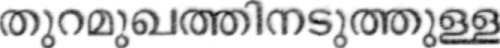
തുറമുഖത്തിനടുത്തുള്ള
